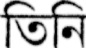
তিনি
